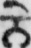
ਨੇ
